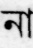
না
